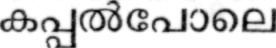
കപ്പല്‍പോലെ
